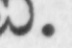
ಐ.
